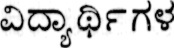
ವಿದ್ಯಾರ್ಥಿಗಳ
